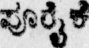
ಪೂರೈಕೆ
